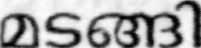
മടങ്ങി
